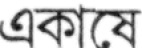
একাষে
